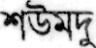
শউমদু
